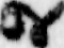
જ
